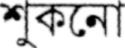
শুকনো
